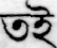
তই
